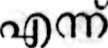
എന്ന്
